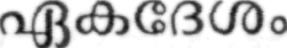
ഏകദേശം
